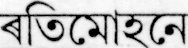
ৰতিমোহনে
